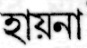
হায়না
